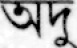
অদু
